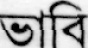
ভাবি
